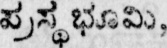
ಪ್ರಸ್ಥಭೂಮಿ,
